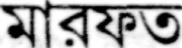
মারফত
